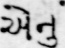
એનું
